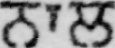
ਨਾਲ
